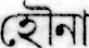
হৌনা
